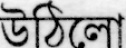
উঠিলো
